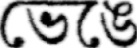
ভেঙে
